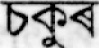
চকুৰ
